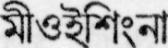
মীওইশিংনা
